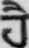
ਹੈ
